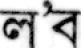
ল'ব
